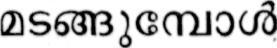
മടങ്ങുമ്പോള്‍
